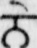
ਨੇ
